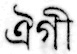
ঐগী
